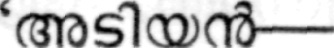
'അടിയന്‍-
